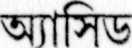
অ্যাসিড
